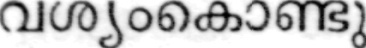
വശ്യംകൊണ്ടു
